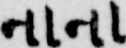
નાના
